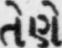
તેણે
